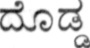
ದೊಡ್ಡ
